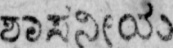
ಶಾಸನೀಯ
